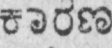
ಕಾರಣ
